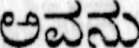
ಅವನು
